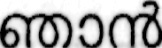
ഞാന്‍
